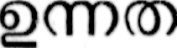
ഉന്നത
